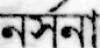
নর্সনা
